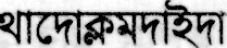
থাদোক্লমদাইদা
